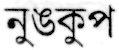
নুঙকুপ
